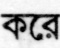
করে
